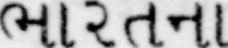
ભારતના
